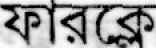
ফারক্লে
